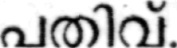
പതിവ്.
